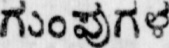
ಗುಂಪುಗಳ
